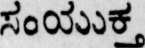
ಸಂಯುಕ್ತ
